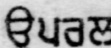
ਉਪਰਲ
